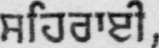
ਸਹਿਰਾਈ,
